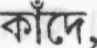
কাঁদে,
